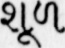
શૂળ
